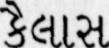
કૈલાસ
